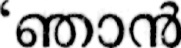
'ഞാന്‍
